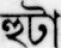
হুটা
